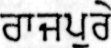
ਰਾਜਪੁਰੇ
